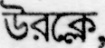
উরক্লে,
